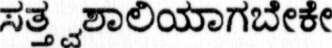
ಸತ್ತ್ವಶಾಲಿಯಾಗಬೇಕೇ
